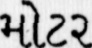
મોટર
